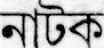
নাটক
